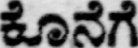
ಕೊನೆಗೆ
